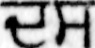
ਦਸ
